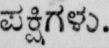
ಪಕ್ಷಿಗಳು.
